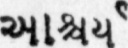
આશ્ચર્ય
